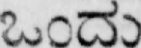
ಒಂದು
